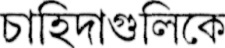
চাহিদাগুলিকে
